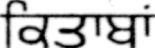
ਕਿਤਾਬਾਂ
